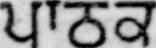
ਪਾਠਕ
